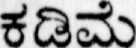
ಕಡಿಮೆ
